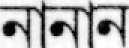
নানান
